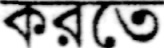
করতে
